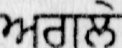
ਅਗਲੇ
